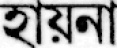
হায়না
